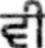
ਵੀ
